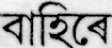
বাহিৰে
